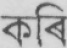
কৰি
